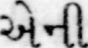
એની
